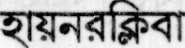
হায়নরক্লিবা
